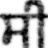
ਸੀ
